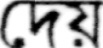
দেয়
